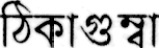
ঠিকাগুম্বা
